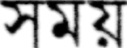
সময়
